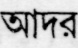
আদর
